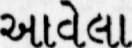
આવેલા
